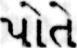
પોતે
